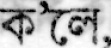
ক'লে,
